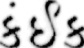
કંઈક
